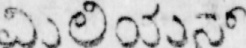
ಮಿಲಿಯನ್
